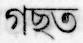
গছত
